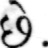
છે.
